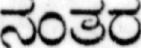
ನಂತರ
